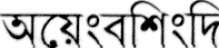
অয়েংবশিংদি
